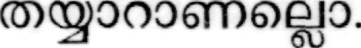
തയ്യാറാണല്ലൊ.
